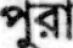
পুরা
